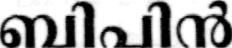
ബിപിന്‍
